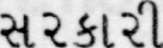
સરકારી
